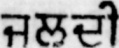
ਜਲਦੀ
